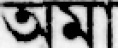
অমা
